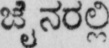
ಜೈನರಲ್ಲಿ
